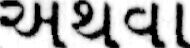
અથવા
